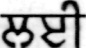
ਲਈ
